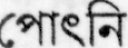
পোৎনি
